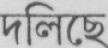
দলিছে
